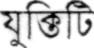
যুক্তিটি
